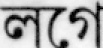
লগে
